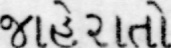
જાહેરાતો
